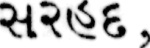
સરહદ,
